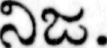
ನಿಜ.
